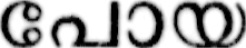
പോയ
